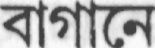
বাগানে
